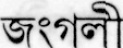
জংগলী
